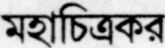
মহাচিত্রকর
